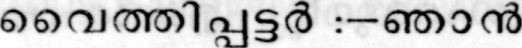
വൈത്തിപ്പട്ടര്‍:-ഞാന്‍
